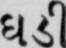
ઘડી
